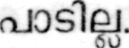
പാടില്ല.
